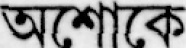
অশোকে
